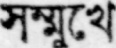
সম্মুখে
